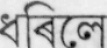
ধৰিলে
